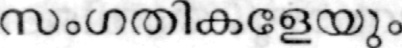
സംഗതികളേയും
